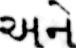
અને
